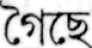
গৈছে
